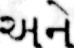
અને
